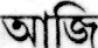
আজি
